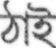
ঠাই
